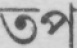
তপ
